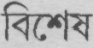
বিশেষ
